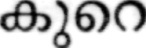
കുറെ
